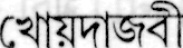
খোয়দাজবী
